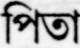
পিতা
